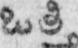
ಒತ್ತಿ
